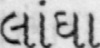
લાંઘા
